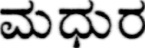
ಮಧುರ
